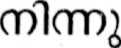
നിന്നു
